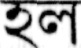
হল
